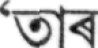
'তাৰ
